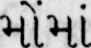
મોંમાં
